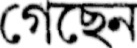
গেছেন
